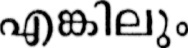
എങ്കിലും
